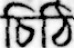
চিঠি
